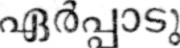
ഏര്‍പ്പാടു
